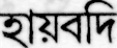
হায়বদি
